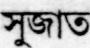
সুজাত
